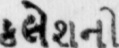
કલેશની
